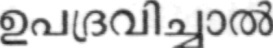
ഉപദ്രവിച്ചാല്‍
